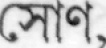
সোণ,
